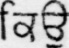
ਕਿਉ
